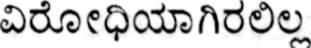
ವಿರೋಧಿಯಾಗಿರಲಿಲ್ಲ
